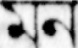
মন
